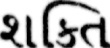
શક્તિ
